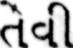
તેવી
